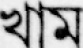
খাম
